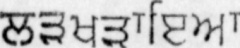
ਲੜਖੜਾਇਆ
